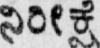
ನಿರೀಕ್ಷೆ
